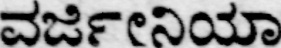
ವರ್ಜೀನಿಯಾ
